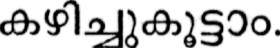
കഴിച്ചുകൂട്ടാം.
